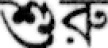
শুরু
